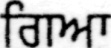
ਗਿਆ
